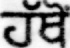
ਹੱਥੋਂ
